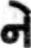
ને
